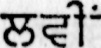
ਲਵੀਂ
